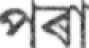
পৰা
